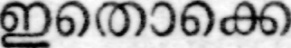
ഇതൊക്കെ
